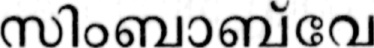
സിംബാബ്വേ
